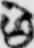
છે
